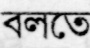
বলতে
